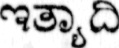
ಇತ್ಯಾದಿ
